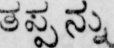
ತಪ್ಪನ್ನು
